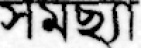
সমছ্যা
